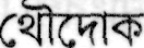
থৌদোক
